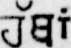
ਹੱਥਾਂ
